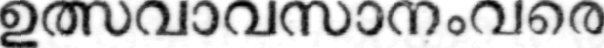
ഉത്സവാവസാനംവരെ
